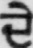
ਦੇ
